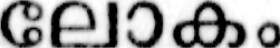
ലോകം
